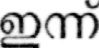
ഇന്ന്
